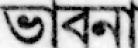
ভাবনা
